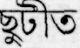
ছুটীত
